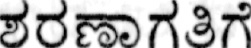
ಶರಣಾಗತಿಗೆ
